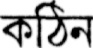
কঠিন
